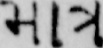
માત્ર
